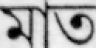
মাত
